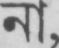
না,
